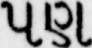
પણ
